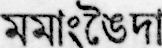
মমাংঙৈদা
